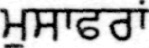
ਮੁਸਾਫਰਾਂ
